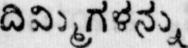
ದಿಮ್ಮಿಗಳನ್ನು
